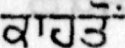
ਕਾਹਤੋਂ
